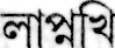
লাপ্নখি
